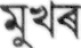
মুখৰ
